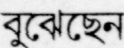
বুঝেছেন
